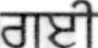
ਗਈ
